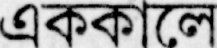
এককালে
